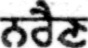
ਨਰੈਣ
